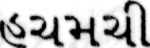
હચમચી
